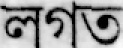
লগত
